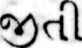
જીતી
